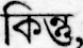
কিন্তু,
